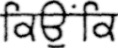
ਕਿਉਂਕਿ
